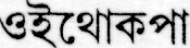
ওইথোকপা
